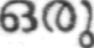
ഒരു
